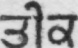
ਤੀਕ
